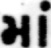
માં
